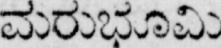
ಮರುಭೂಮಿ
